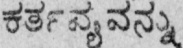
ಕರ್ತವ್ಯವನ್ನು
